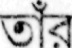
তাঁর
